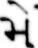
મેં
